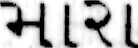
મારા
